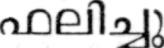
ഫലിച്ചു
